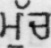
ਮੁੱਚ
